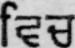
ਵਿਚ
